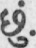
છું.
